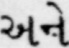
અને
